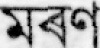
মৰণ
